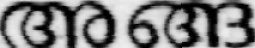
അങ്ങ
